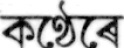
কণ্ঠেৰে
